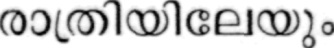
രാത്രിയിലേയും
